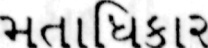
મતાધિકાર
